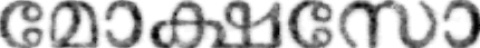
മോക്ഷസോ
